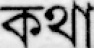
কথা
